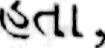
હતા,
